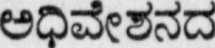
ಅಧಿವೇಶನದ
